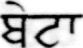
ਬੇਟਾ
